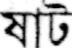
ষাট
